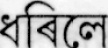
ধৰিলে
